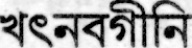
খৎনবগীনি
